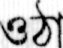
ওঠা
